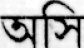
অসি
